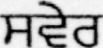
ਸਵੇਰ
